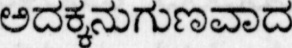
ಅದಕ್ಕನುಗುಣವಾದ
